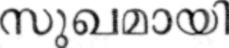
സുഖമായി
